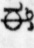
ಈ
